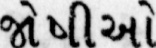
જોષીઓ
